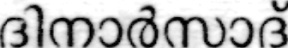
ദിനാര്‍സാദ്
